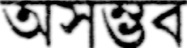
অসম্ভব
